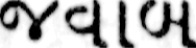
જવાબ
